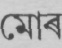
মোৰ
